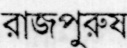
রাজপুরুষ
